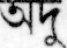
অদু
